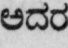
ಅದರ
